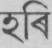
হৰি
